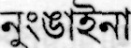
নুংঙাইনা
